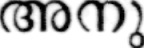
അനു
